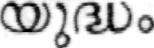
യുദ്ധം
